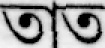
তাত
